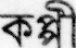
কপ্পী
